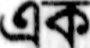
এক
